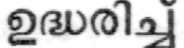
ഉദ്ധരിച്ച്
